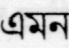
এমন
